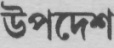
উপদেশ
